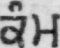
ਕੰਮ
